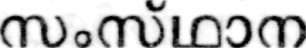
സംസ്ഥാന
